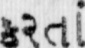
કરતાં
